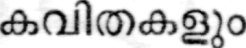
കവിതകളും
